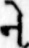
ને
